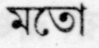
মতো
